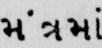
મંત્રમાં
